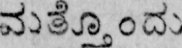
ಮತ್ತೊಂದು
